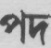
পদ
